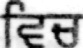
ਵਿਚ
